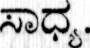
ಸಾಧ್ಯ.
